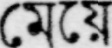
মেয়ে
